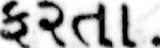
ફરતા.
